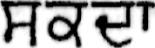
ਸਕਦਾ
